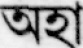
অহা
